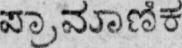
ಪ್ರಾಮಾಣಿಕ
